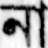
না
